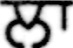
ਲਾ
